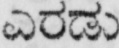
ಎರಡು
